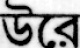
উরে
